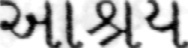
આશ્રય
